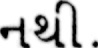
નથી.
